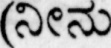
(ನೀನು
